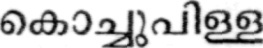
കൊച്ചുപിള്ള
